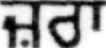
ਜ਼ਰਾ
